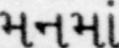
મનમાં
